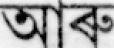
আৰু
